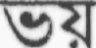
ভয়
